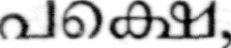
പക്ഷെ,
